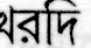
খরদি
